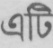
এটি
